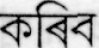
কৰিব
